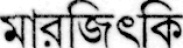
মারজিৎকি
